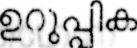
ഉറുപ്പിക
